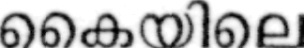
കൈയിലെ
